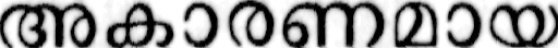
അകാരണമായ
